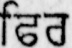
ਫਿਰ
